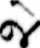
જે
